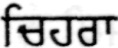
ਚਿਹਰਾ
